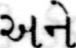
અને
